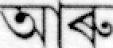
আৰু
